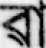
ৱা
